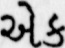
એક
